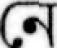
নে
